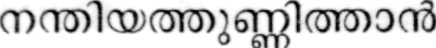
നന്തിയത്തുണ്ണിത്താന്‍
